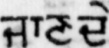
ਜਾਣਦੇ
